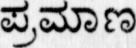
ಪ್ರಮಾಣ
